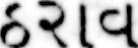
ઠરાવ
